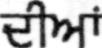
ਦੀਆਂ
